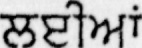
ਲਈਆਂ
